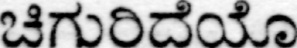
ಚಿಗುರಿದೆಯೊ
